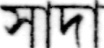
সাদা
